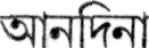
আনদিনা
